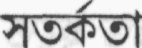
সতর্কতা
